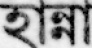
হান্না
